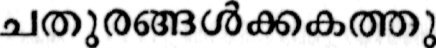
ചതുരങ്ങള്‍ക്കകത്തു
